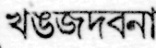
খঙজদবনা
